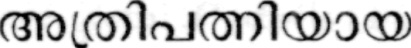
അത്രിപത്നിയായ
